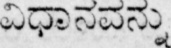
ವಿಧಾನವನ್ನು
